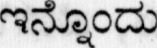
ಇನ್ನೊಂದು
